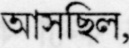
আসছিল,
